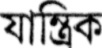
যান্ত্রিক
